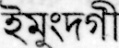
ইমুংদগী
